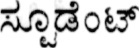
ಸ್ಟೂಡೆಂಟ್
